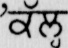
'ਕੱਲ੍ਹ
